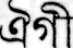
ঐগী
